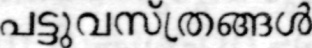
പട്ടുവസ്ത്രങ്ങള്‍
